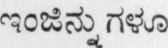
ಇಂಜಿನ್ನುಗಳೂ
